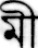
মী
